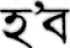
হ'ব
